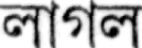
লাগল
